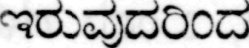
ಇರುವುದರಿಂದ
